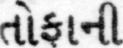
તોફાની
